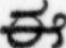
ಈ
